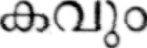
കവും
